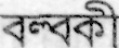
বল্বকী
